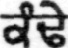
ਕੰਢੇ
